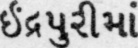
ઇંદ્રપુરીમાં
